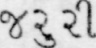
જરુરી
